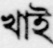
খাই
